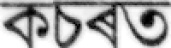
কচৰত
